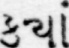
ક્યાં
